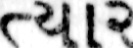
ત્યાર
